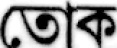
তোক
